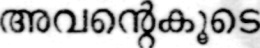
അവന്റെകൂടെ
